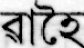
ৱাহৈ
